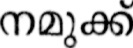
നമുക്ക്
